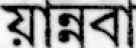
য়ান্নবা
